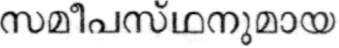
സമീപസ്ഥനുമായ
